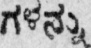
ಗಳನ್ನು
